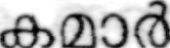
കമാര്‍
